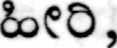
ಹೀರಿ,
